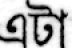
এটা
